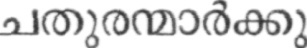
ചതുരന്മാര്‍ക്കു
